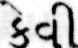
કેવી
